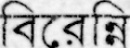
বিরেন্নি
